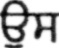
ਉਸ
